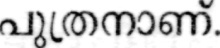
പുത്രനാണ്.
